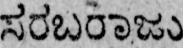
ಸರಬರಾಜು
